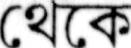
থেকে
